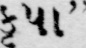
કૃપા”
